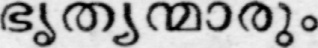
ഭൃത്യന്മാരും
